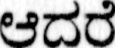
ಆದರೆ
